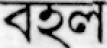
বহল
